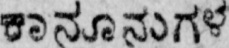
ಕಾನೂನುಗಳ
